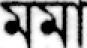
মমা
